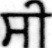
ਸੀ
